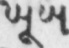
ખૂબ
